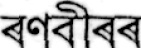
ৰণবীৰৰ
